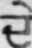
ਦੇ
